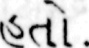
હતો.
